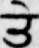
ਤੇ
